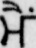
ਮੈਂ
